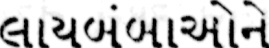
લાયબંબાઓને
